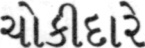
ચોકીદારે
